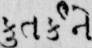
કુતર્કને
